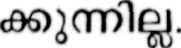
ക്കുന്നില്ല.
